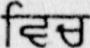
ਵਿਚ
